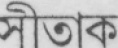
সীতাক
